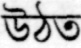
উঠত
